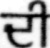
ਦੀ
